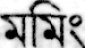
মমিং
